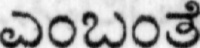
ಎಂಬಂತೆ
